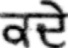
ਕਦੇ
